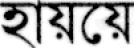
হায়য়ে
